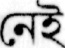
নেই
